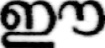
ഈ
